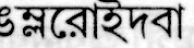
ঙম্লরোইদবা
